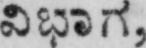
ವಿಭಾಗ,
